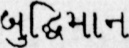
બુદ્ધિમાન
